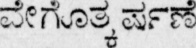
ವೇಗೊತ್ಕರ್ಷಣೆ
